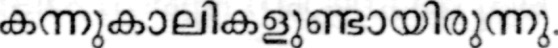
കന്നുകാലികളുണ്ടായിരുന്നു.
